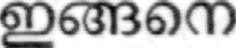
ഇങ്ങനെ
